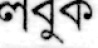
লবুক
